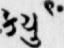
કર્યું
